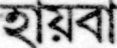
হায়বা
